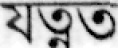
যত্নত
